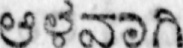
ಆಳವಾಗಿ
